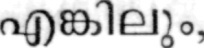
എങ്കിലും,
